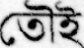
তৌই
